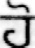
ਹੋ
